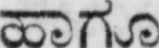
ಹಾಗೂ
